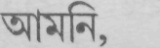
আমনি,
